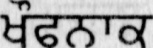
ਖੌਫਨਾਕ
